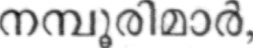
നമ്പൂരിമാര്‍,
